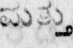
ಮತ್ತು
